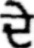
ਦੇ
